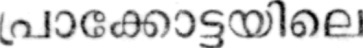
പ്രാക്കോട്ടയിലെ
